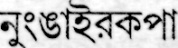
নুংঙাইরকপা
